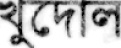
খুদোল
